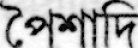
পৈশাদি
